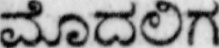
ಮೊದಲಿಗ
